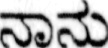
ನಾನು
